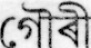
গৌৰী
